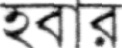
হবার
